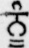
ਨੂੰ
